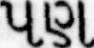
પણ
